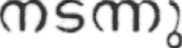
നടന്നു
